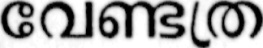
വേണ്ടത്ര
